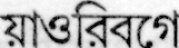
য়াওরিবগে
